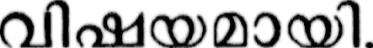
വിഷയമായി.
